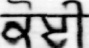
ਕੋਈ
